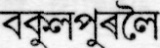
বকুলপুৰলৈ
